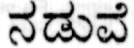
ನಡುವೆ
